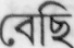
বেছি
